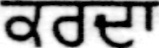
ਕਰਦਾ
